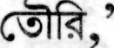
তৌরি,’
